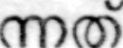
ന്നത്
